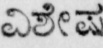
ವಿಶೇಷ
